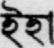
ইহা
